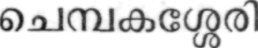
ചെമ്പകശ്ശേരി
